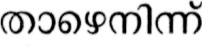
താഴെനിന്ന്
